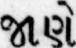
જાણે
